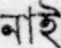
নাই
